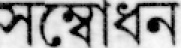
সম্বোধন
